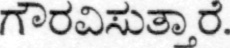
ಗೌರವಿಸುತ್ತಾರೆ.
